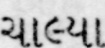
ચાલ્યા
